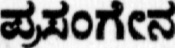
ಪ್ರಸಂಗೇನ
